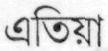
এতিয়া
